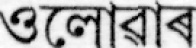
ওলোৱাৰ
